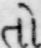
તો
